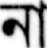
না
